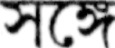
সঙ্গে
